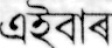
এইবাৰ
